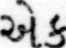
એક
